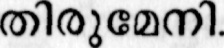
തിരുമേനി.
